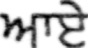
ਆਏ
